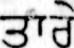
ਤਾਰੇ
